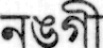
নঙগী
